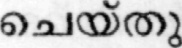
ചെയ്തു
